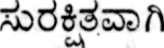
ಸುರಕ್ಷಿತವಾಗಿ
